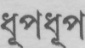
ধূপধূপ
